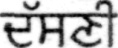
ਦੱਸਣੀ
